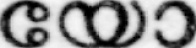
യോ
